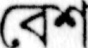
বেশ
